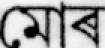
মোৰ
